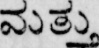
ಮತ್ತು
